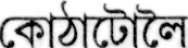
কোঠাটোলৈ
